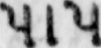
પાપ
